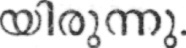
യിരുന്നു.
